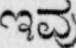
ಇವು
